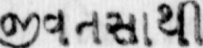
જીવનસાથી
